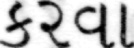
કરવા
